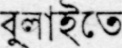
বুলাইতে
